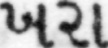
ખરા
